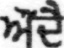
ਔਂਦੈ
